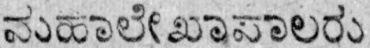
ಮಹಾಲೇಖಾಪಾಲರು
